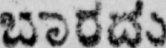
ಬಾರದು
